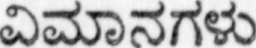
ವಿಮಾನಗಳು
